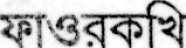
ফাওরকখি
